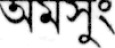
অমসুং
